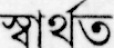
স্বার্থত
